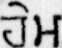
ਹੇਮ
